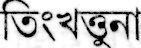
তিংখত্তুনা
